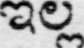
ಇಲ್ಲ
